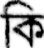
কি
